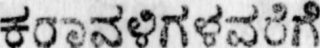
ಕರಾವಳಿಗಳವರೆಗೆ
